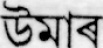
উমাৰ
